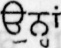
ਉਨ੍ਹਾਂ
